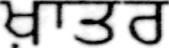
ਖ਼ਾਤਰ
